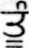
ਤੂੰ
